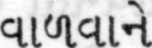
વાળવાને
